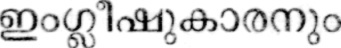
ഇംഗ്ലീഷുകാരനും
